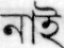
নাই
